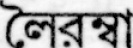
লৈরম্বা
